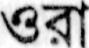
ওরা
